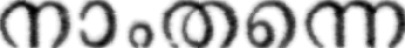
നാംതന്നെ
